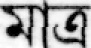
মাত্র
